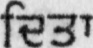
ਦਿਤਾ
